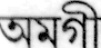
অমগী
